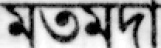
মতমদা
